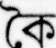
কৈ
